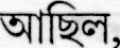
আছিল,
